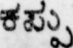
ಕಪ್ಪು
